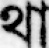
থা
